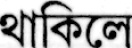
থাকিলে
